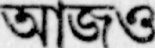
আজও
